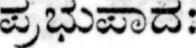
ಪ್ರಭುಪಾದ:
